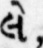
લે,
